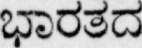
ಭಾರತದ
